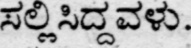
ಸಲ್ಲಿಸಿದ್ದವಳು.
